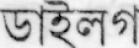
ডাইলগ
